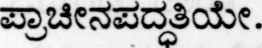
ಪ್ರಾಚೀನಪದ್ಧತಿಯೇ.
